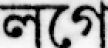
লগে
